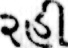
રહી
